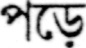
পড়ে
